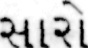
સારો
